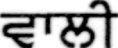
ਵਾਲੀ
